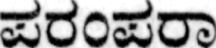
ಪರಂಪರಾ
